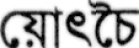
য়োৎচৈ
